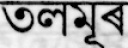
তলমূৰ
